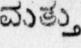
ಮತ್ತು
